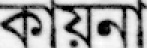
কায়না
